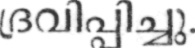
ദ്രവിപ്പിച്ചു.
